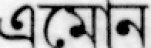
এমোন
